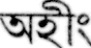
অহীং
